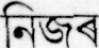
নিজৰ
